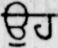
ਉਹ
